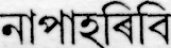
নাপাহৰিবি
